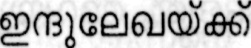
ഇന്ദുലേഖയ്ക്ക്
